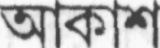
আকাশ
